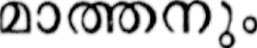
മാത്തനും
